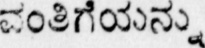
ವಂತಿಗೆಯನ್ನು
